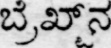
ಬ್ರೆಖ್ಟ್‌ನ
